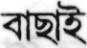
বাছাই
